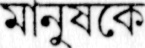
মানুষকে
